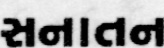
સનાતન
